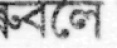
ৰুবলে
